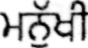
ਮਨੁੱਖੀ
